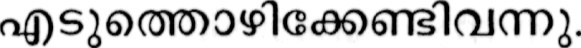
എടുത്തൊഴിക്കേണ്ടിവന്നു.
